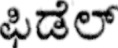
ಫಿಡೆಲ್
